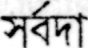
সর্বদা
